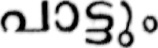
പാട്ടും
